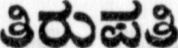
ತಿರುಪತಿ
